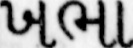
ખભા
